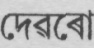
দেৱৰো
